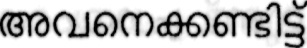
അവനെക്കണ്ടിട്ട്
